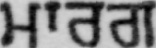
ਮਾਰਗ
